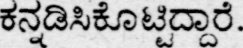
ಕನ್ನಡಿಸಿಕೊಟ್ಟಿದ್ದಾರೆ.
